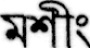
মশীং
